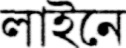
লাইনে
